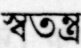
স্বতন্ত্র
